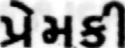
પ્રેમકી
